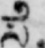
ಸೆ.
